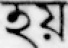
হয়
